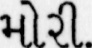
મોરી.
